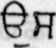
ਉਸ
